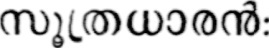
സൂത്രധാരന്‍:
